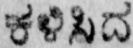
ಕಳಿಸಿದ
